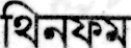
থিনফম
